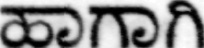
ಹಾಗಾಗಿ
